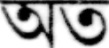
অত
